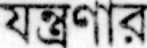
যন্ত্রণার
